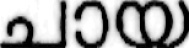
ചായ
